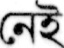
নেই
